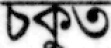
চকুত
